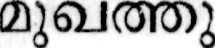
മുഖത്തു
